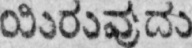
ಯಿರುವುದು
